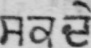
ਸਕਦੇ
